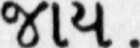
જાય.
